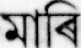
মাৰি
